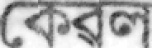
কেৱল
